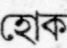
হোক
